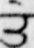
ਤੇ
